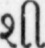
શી
